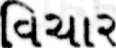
વિચાર
